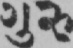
ગુરુ
